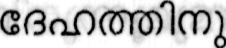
ദേഹത്തിനു
